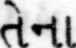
તેના
